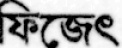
ফিজেৎ
